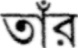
তাঁর
